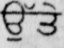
ਉੱਤੇ
